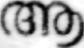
ആ
